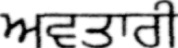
ਅਵਤਾਰੀ
